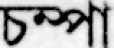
চম্পা
